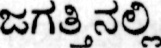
ಜಗತ್ತಿನಲ್ಲಿ
